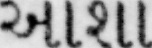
આશા
